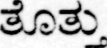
ತೊತ್ತು
